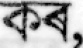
কৰ,
